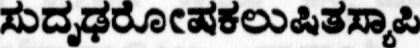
ಸುದೃಢರೋಷಕಲುಷಿತಸ್ಯಾಪಿ
